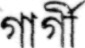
গার্গী
